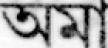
অমা
